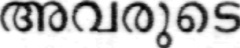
അവരുടെ
